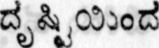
ದೃಷ್ಟಿಯಿಂದ
